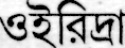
ওইরিদ্রা
